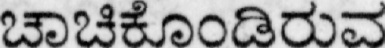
ಚಾಚಿಕೊಂಡಿರುವ
